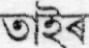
তাইৰ
